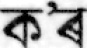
ক'ৰ
